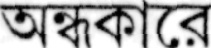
অন্ধকারে
